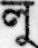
লু
